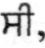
ਸੀ,
